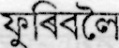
ফুৰিবলৈ
